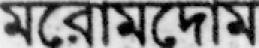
মরোমদোম
